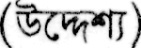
(উদ্দেশ্য)
